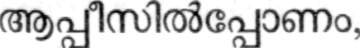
ആപ്പീസില്‍പ്പോണം,
